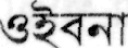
ওইবনা
